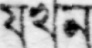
যখন
